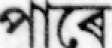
পাৰে
